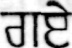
ਗਏ
